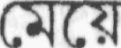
মেয়ে
